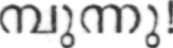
മ്പുന്നു!
